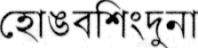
হোঙবশিংদুনা
